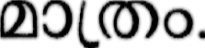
മാത്രം.
